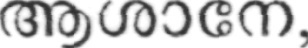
ആശാനേ,
